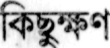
কিছুক্ষণ
